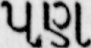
પણ
